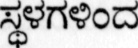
ಸ್ಥಳಗಳಿಂದ
